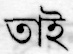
তাই
